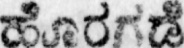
ಹೊರಗಡೆ
